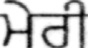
ਮੇਰੀ
